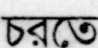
চরতে
